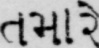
તમારે
